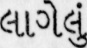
લાગેલું
